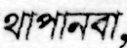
থাপানবা,
